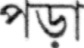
পড়া
